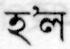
হ'ল
